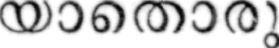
യാതൊരു
